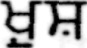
ਖ਼ੁਸ਼
